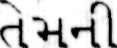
તેમની
